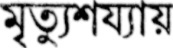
মৃত্যুশয্যায়
